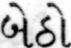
બેઠો
